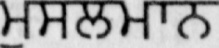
ਮੁਸਲਮਾਨ
